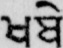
ਖਬੇ
